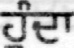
ਹੁੰਦਾ
